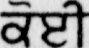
ਕੋਈ
